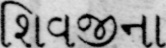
શિવજીના
